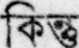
কিন্তু
